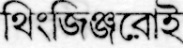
থিংজিঞ্জরোই
